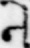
ને
